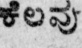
ಕೆಲವು
